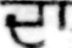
ਦਾ
